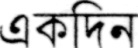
একদিন
